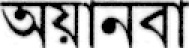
অয়ানবা
